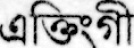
এক্তিংগী
